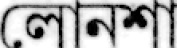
লোনশা
